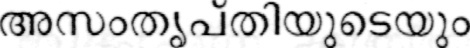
അസംതൃപ്തിയുടെയും
